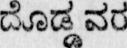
ದೊಡ್ಡವರ
